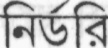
নির্ডরি
